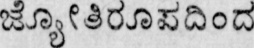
ಜ್ಯೋತಿರೂಪದಿಂದ
